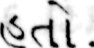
હતો.
